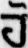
ਹੋ
